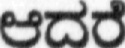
ಆದರೆ
